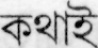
কথাই
